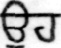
ਉਹ
